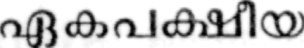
ഏകപക്ഷീയ
